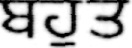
ਬਹੁਤ
